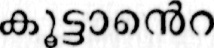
കൂട്ടാന്റെ
